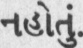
નહોતું.
